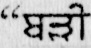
''ਬੜੀ
